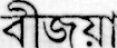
বীজয়া
